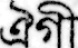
ঐগী
